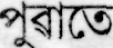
পুৱাতে
